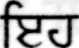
ਇਹ
